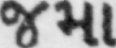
જમા
